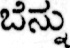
ಬೆನ್ನು
